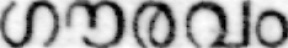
ഗൌരവം
